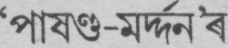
'পাষণ্ড-মৰ্দ্দন'ৰ
